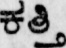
ಕತ್ತಿ
